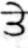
ਤੇ
